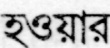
হওয়ার
